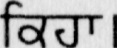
ਕਿਹਾ।
